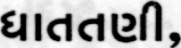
ધાતતણી,
